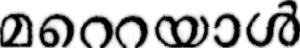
മറെറ യാൾ
